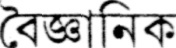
বৈজ্ঞানিক
